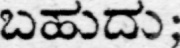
ಬಹುದು;
